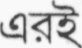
এরই
